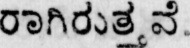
ರಾಗಿರುತ್ತವೆ.
